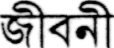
জীবনী
